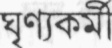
ঘৃণ্যকর্মী
